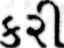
કરી
